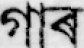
গাৰ
